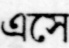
এসে
